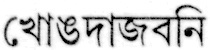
খোঙদাজবনি
